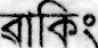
ৱাকিং
